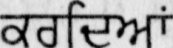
ਕਰਦਿਆਂ
